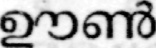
ഊണ്‍
